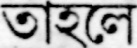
তাহলে
